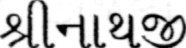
શ્રીનાથજી
